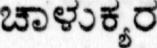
ಚಾಳುಕ್ಯರ
